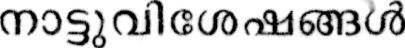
നാട്ടുവിശേഷങ്ങള്‍
